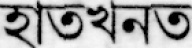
হাতখনত
